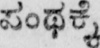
ಪಂಥಕ್ಕೆ
